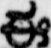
ಈ
